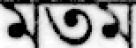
মতম
